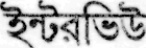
ইন্টরভিউ
